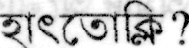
হাৎতোক্লি?
